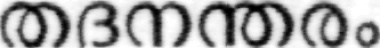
തദനന്തരം
